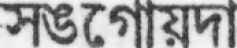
সঙগোয়দা
